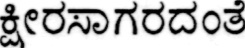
ಕ್ಷೀರಸಾಗರದಂತೆ
